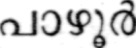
പാഴൂര്‍
